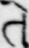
તે
